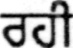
ਰਹੀ
